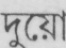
দুয়ো
